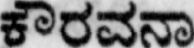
ಕೌರವನಾ
